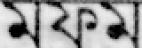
মফম
